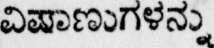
ವಿಷಾಣುಗಳನ್ನು
